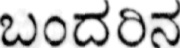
ಬಂದರಿನ
